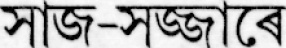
সাজ-সজ্জাৰে
